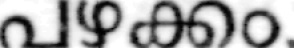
പഴക്കം.
